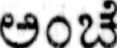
ಅಂಚೆ
